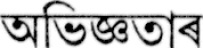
অভিজ্ঞতাৰ
